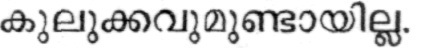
കുലുക്കവുമുണ്ടായില്ല.
